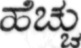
ಹೆಚ್ಚು
